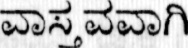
ವಾಸ್ತವವಾಗಿ
